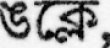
ঙক্লে,
